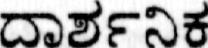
ದಾರ್ಶನಿಕ
